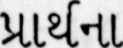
પ્રાર્થના
